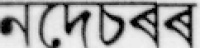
নদেচৰৰ
